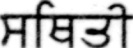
ਸਥਿਤੀ
